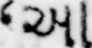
આ
